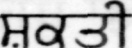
ਸ਼ਕਤੀ
